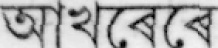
আখৰেৰে
